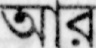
আর
